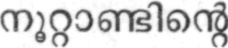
നൂറ്റാണ്ടിന്റെ
